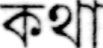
কথা
